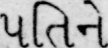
પતિને
